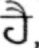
ਹੈ,
